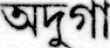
অদুগা
